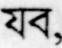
যব,
